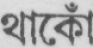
থাকোঁ
